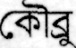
কৌব্রু
